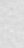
યે
